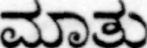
ಮಾತು
